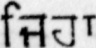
ਜਿਹਾ
